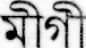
মীগী
